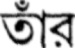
তাঁর
